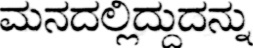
ಮನದಲ್ಲಿದ್ದುದನ್ನು
